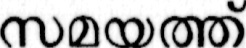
സമയത്ത്
